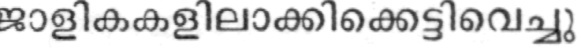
ജാളികകളിലാക്കിക്കെട്ടിവെച്ചു
